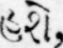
હશે,
